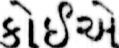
કોઈએ
